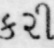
કરી
